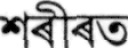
শৰীৰত
